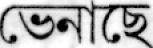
ভেনাছে
